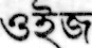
ওইজ
